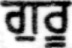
ਗੁਰੂ
